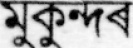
মুকুন্দৰ
